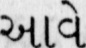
આવે
